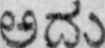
ಅದು
